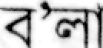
ব'লা
